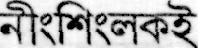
নীংশিংলকই
